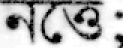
নত্তে;
